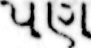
પણ
